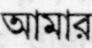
আমার
